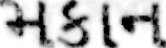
મકાન
